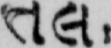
તલ,
